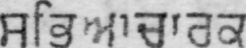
ਸਭਿਆਚਾਰਕ
